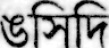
ঙসিদি
